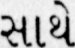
સાથે
